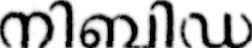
നിബിഡ
